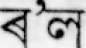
ৰ'ল
